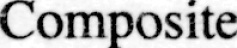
Composite
